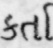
કર્તા
